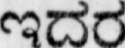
ಇದರ
